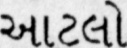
આટલો
